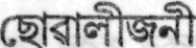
ছোৱালীজনী
